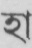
হা
